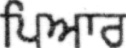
ਪਿਆਰ
